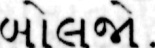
બોલજો.
